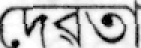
দেৱতা
